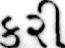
કરી
